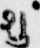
શું
